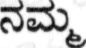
ನಮ್ಮ
